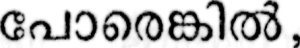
പോരെങ്കില്‍,
